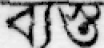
ব্যস্ত
